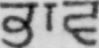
ਭਾਵ
